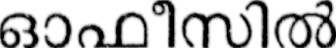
ഓഫീസില്‍
